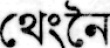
থেংনৈ
